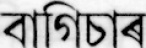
বাগিচাৰ
